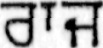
ਰਾਜ
